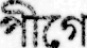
পীগে
